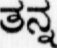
ತನ್ನ
